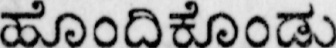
ಹೊಂದಿಕೊಂಡು
